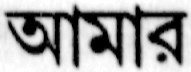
আমার
